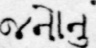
જનોનું
